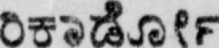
ರಿಕಾರ್ಡೋ
